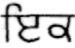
ਇਕ
